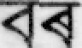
বৰ
